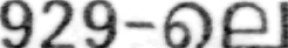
929-ലെ
